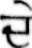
ਦੇ
